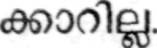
ക്കാറില്ല.
